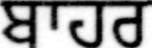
ਬਾਹਰ
